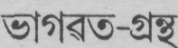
ভাগৱত-গ্ৰন্থ
